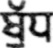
ਬੁੱਧ
